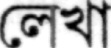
লেখা
